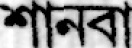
শানবা
